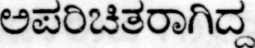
ಅಪರಿಚಿತರಾಗಿದ್ದ
